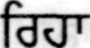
ਰਿਹਾ
